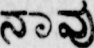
ನಾವು
